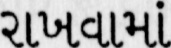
રાખવામાં
